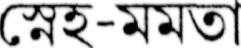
স্নেহ-মমতা
